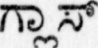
ಗ್ಲಾಸ್
